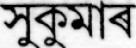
সুকুমাৰ
